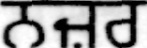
ਨਜ਼ਰ
